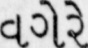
વગેરે
